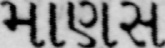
માણસ
